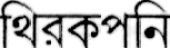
থিরকপনি
